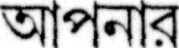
আপনার
